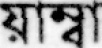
য়াম্বা
